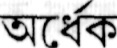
অর্ধেক
